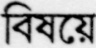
বিষয়ে
